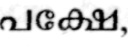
പക്ഷേ,
